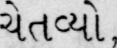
ચેતવ્યો,
